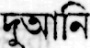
দুআনি
